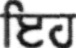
ਇਹ
